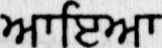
ਆਇਆ
